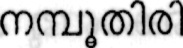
നമ്പൂതിരി
